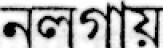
নলগায়
